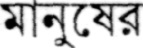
মানুষের
